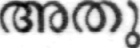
അതു
